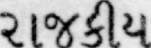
રાજકીય
